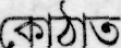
কোঠাত
